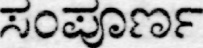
ಸಂಪೂರ್ಣ
